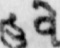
હવે
